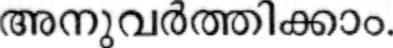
അനുവര്‍ത്തിക്കാം.
